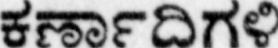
ಕರ್ಣಾದಿಗಳಿ
